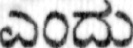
ಎಂದು
